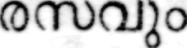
രസവും
